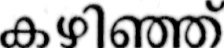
കഴിഞ്ഞ്
